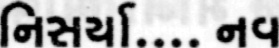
નિસર્યા.......નવ
